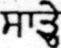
ਸਾੜ੍ਹੇ
